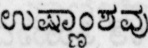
ಉಷ್ಣಾಂಶವು
